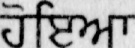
ਹੋਇਆ
